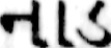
નાડ
